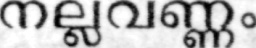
നല്ലവണ്ണം
